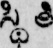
ಸ್ಥಿತಿ
